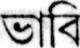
ভাবি
